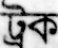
ট্রক
